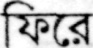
ফিরে
